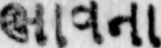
ભાવના
